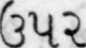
ઉપર
